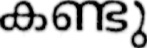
കണ്ടു
